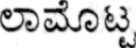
ಲಾಮೊಟ್ಟ
